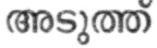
അടുത്ത്
